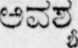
ಅವಶ್ಯ
